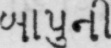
બાપુની
